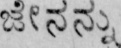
ಜೇನನ್ನು
